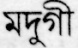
মদুগী
